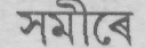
সমীৰে
